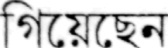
গিয়েছেন
